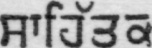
ਸਾਹਿੱਤਕ
